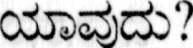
ಯಾವುದು?
